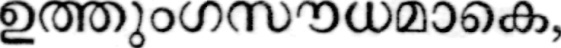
ഉത്തുംഗസൌധമാകെ,
